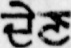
ਦੇਣ
